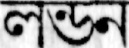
লন্ডন
